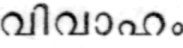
വിവാഹം
